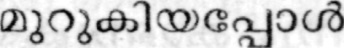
മുറുകിയപ്പോള്‍
